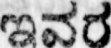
ಇವರ
